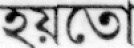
হয়তো
